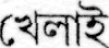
খেলাই
